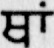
ਥਾਂ
